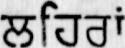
ਲਹਿਰਾਂ
